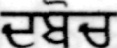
ਦਬੋਚ
